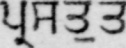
ਪ੍ਰਸਤੁਤ
